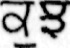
ਕੁਝ
